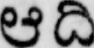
ಆದಿ
